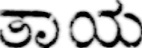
ತಾಯ
